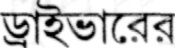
ড্রাইভারের
